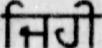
ਜਿਹੀ
